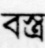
বস্ত্র
